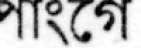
পাংগে
